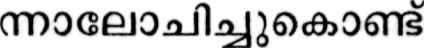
ന്നാലോചിച്ചുകൊണ്ട്
